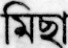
মিছা
